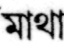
মাথা
